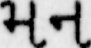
મન
